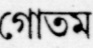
গোতম
